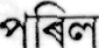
পৰিল
